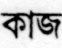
কাজ
